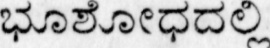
ಭೂಶೋಧದಲ್ಲಿ
